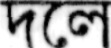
দলে
